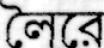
লৈরে
